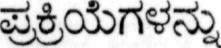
ಪ್ರಕ್ರಿಯೆಗಳನ್ನು
